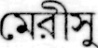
মেরীসু
